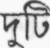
দুটি
